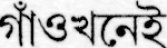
গাঁওখনেই
